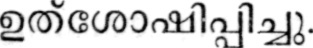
ഉത്ശോഷിപ്പിച്ചു.
